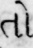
તો
